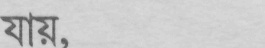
যায়,
